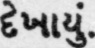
દેખાયું.
